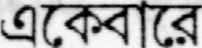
একেবারে
